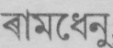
ৰামধেনু,
